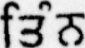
ਤਿੰਨ
